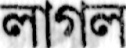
লাগল
